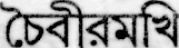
চৈবীরমখি
